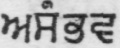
ਅਸੰਭਵ
